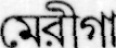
মেরীগা
